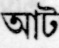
আট
